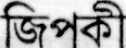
জিপকী
